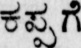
ಕಪ್ಪಗೆ
